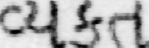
વ્યકત
